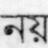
নয়
